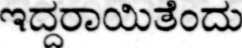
ಇದ್ದರಾಯಿತೆಂದು
